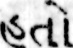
હતો
